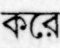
করে
